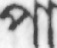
পা
